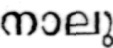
നാലു
